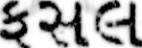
ફસલ
